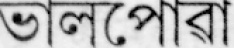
ভালপোৱা
